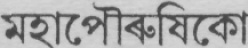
মহাপৌৰুষিকো
